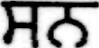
ਸਨ
